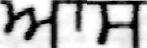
ਆਸ
